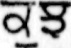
ਕੁਝ
